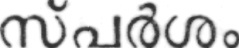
സ്പര്‍ശം
